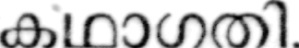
കഥാഗതി.
